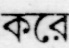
করে
